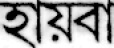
হায়বা
